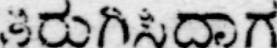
ತಿರುಗಿಸಿದಾಗ
